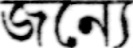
জন্যে
